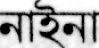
নাইনা
